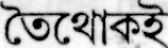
তৈথোকই
